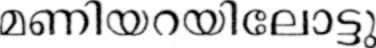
മണിയറയിലോട്ടു
